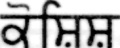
ਕੋਸ਼ਿਸ਼
